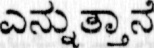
ಎನ್ನುತ್ತಾನೆ
